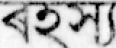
ৰহস্য
